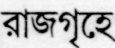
রাজগৃহে
